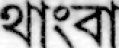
থাংবা
